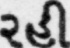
રહી
